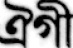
ঐগী
